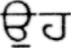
ਉਹ
